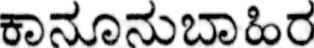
ಕಾನೂನುಬಾಹಿರ
